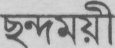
ছন্দময়ী
